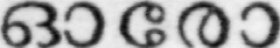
ഓരോ
